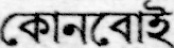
কোনবোই
